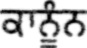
ਕਾਨੂੰਨ
